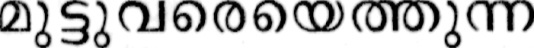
മുട്ടുവരെയെത്തുന്ന
